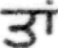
ਤਾਂ
